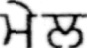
ਮੇਲ
